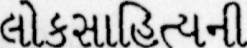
લોકસાહિત્યની
